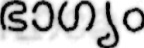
ഭാഗ്യം
